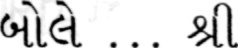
બોલે...શ્રી
